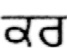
ਕਰ
